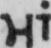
ਮਾਂ
